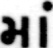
માં
